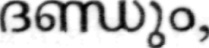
ദണ്ഡും,
